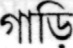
গাড়ি
